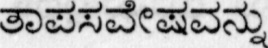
ತಾಪಸವೇಷವನ್ನು
